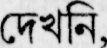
দেখনি,
